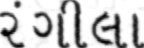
રંગીલા
